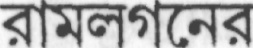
রামলগনের
